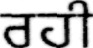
ਰਹੀ
